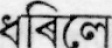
ধৰিলে
